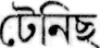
টেনিছ
